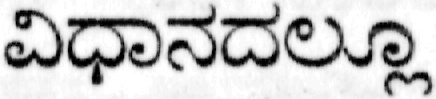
ವಿಧಾನದಲ್ಲೂ
